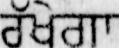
ਰੱਖੇਗਾ
